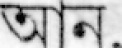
আন,
